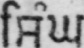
ਸਿੰਘ
